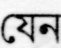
যেন
